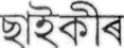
ছাইকীৰ
